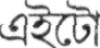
এইটো
